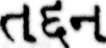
તદ્દન
